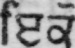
ਇਕੋ
